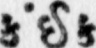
કંઈક
